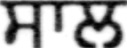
ਸਾਲ
